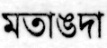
মতাঙদা
